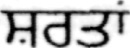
ਸ਼ਰਤਾਂ
